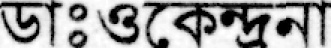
ডাঃওকেন্দ্রনা
